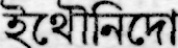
ইথৌনিদো
